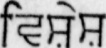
ਵਿਸ਼ੇਸ਼
